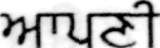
ਆਪਣੀ
